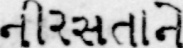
નીરસતાને
